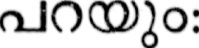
പറയും:
